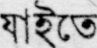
যাইতে
